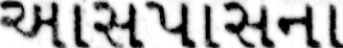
આસપાસના
